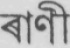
ৰাণী
